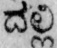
ದಲ್ಲಿ
